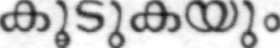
കൂടുകയും
